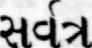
સર્વત્ર
